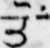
ਤੋਂ
